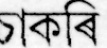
চাকৰি
